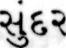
સુંદર
